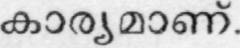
കാര്യമാണ്.
